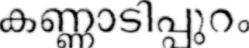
കണ്ണാടിപ്പുറം
